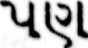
પણ
